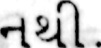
નથી.
